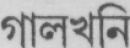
গালখনি
